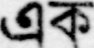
এক
